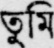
তুমি
